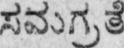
ಸಮಗ್ರತೆ
